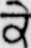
ਕੇ
